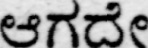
ಆಗದೇ
